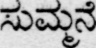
ಸುಮ್ಮನೆ
